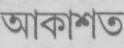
আকাশত
